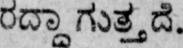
ರದ್ದಾಗುತ್ತದೆ.
